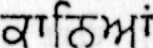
ਕਾਨਿਆਂ
